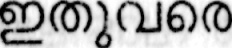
ഇതുവരെ
